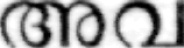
അവ
